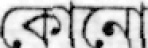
কোনো
